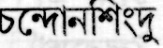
চন্দোনশিংদু
